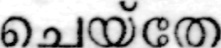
ചെയ്തേ
